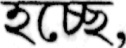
হচ্ছে,
